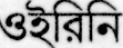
ওইরিনি
